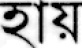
হায়
